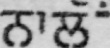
ਨਾਲੋਂ
